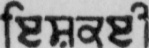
ਇਸ਼ਕਈ
